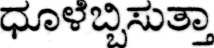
ಧೂಳೆಬ್ಬಿಸುತ್ತಾ
